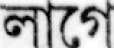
লাগে
